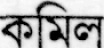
কমিল
